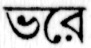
ভরে
